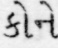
કોને
